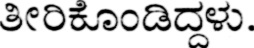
ತೀರಿಕೊಂಡಿದ್ದಳು.
